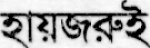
হায়জরুই
